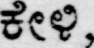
ಕೇಳಿ,
